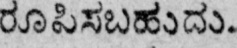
ರೂಪಿಸಬಹುದು.
